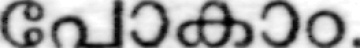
പോകാം.
